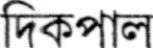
দিকপাল
